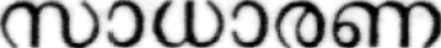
സാധാരണ
